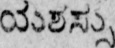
ಯಶಸ್ಸು
